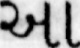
આ
